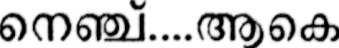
നെഞ്ച്....ആകെ
